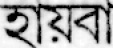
হায়বা
